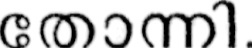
തോന്നി.
